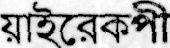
য়াইরেকপী
